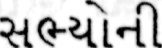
સભ્યોની
